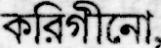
করিগীনো,
